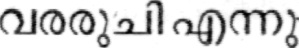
വരരുചിഎന്നു
